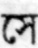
সে
